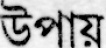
উপায়
